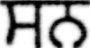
ਸਨ
